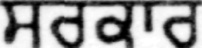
ਸਰਕਾਰ
